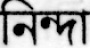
নিন্দা
